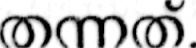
തന്നത്.
